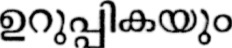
ഉറുപ്പികയും
